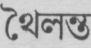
থৈলন্ত
